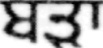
ਬੜਾ
